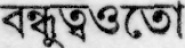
বন্ধুত্বওতো
